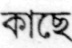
কাছে
